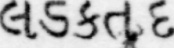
લડકતદ
